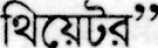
থিয়েটর”
